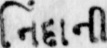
નિંદાની
